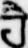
ਹੈ
